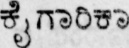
ಕೈಗಾರಿಕಾ
